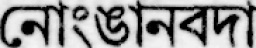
নোংঙানবদা
